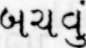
બચવું
